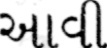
આવી
